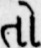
તો
